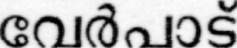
വേര്‍പാട്
